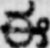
ಈ
